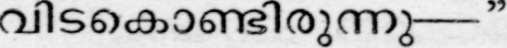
വിടകൊണ്ടിരുന്നു-"
